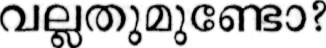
വല്ലതുമുണ്ടോ?
